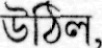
উঠিল,
